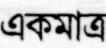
একমাত্র
